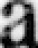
a
